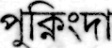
পুক্নিংদা
